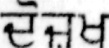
ਦੋਜ਼ਖ
